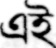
এই
